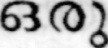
ഒരു
